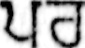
ਪਰ
